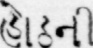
હોઠની
